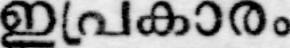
ഇപ്രകാരം
